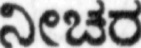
ನೀಚರ
